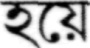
হয়ে
